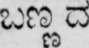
ಬಣ್ಣದ
